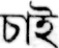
চাই
